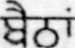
ਬੈਠਾਂ
